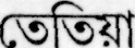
তেতিয়া
